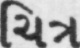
ચિત્ર
